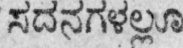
ಸದನಗಳಲ್ಲೂ
